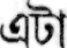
এটা
